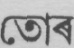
তোৰ
